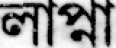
লাপ্না
